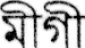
মীগী
